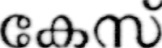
കേസ്
